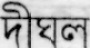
দীঘল
